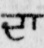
ਦਾ
